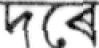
দৰে
